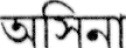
অসিনা
